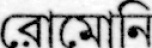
রোমোনি
